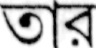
তার
